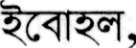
ইবোহল,
